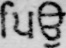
ਪਿਉ
